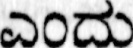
ಎಂದು
